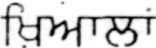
ਖ਼ਿਆਲਾਂ
